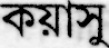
কয়াসু
